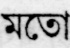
মতো
